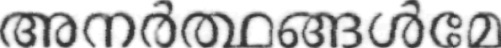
അനര്‍ത്ഥങ്ങള്‍മേ
